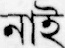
নাই
